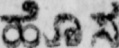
ಹೊಸ
